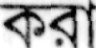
করা
